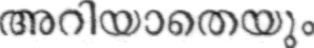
അറിയാതെയും
